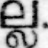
ല്ല.
